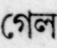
গেল
